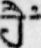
ਹੈਂ
